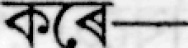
কৰে-
